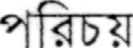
পরিচয়
